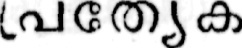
പ്രത്യേക
